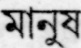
মানুষ
